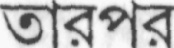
তারপর
